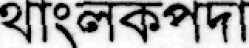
থাংলকপদা
